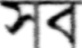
সব
